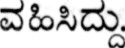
ವಹಿಸಿದ್ದು.
